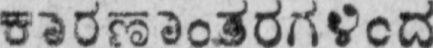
ಕಾರಣಾಂತರಗಳಿಂದ
